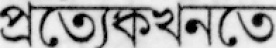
প্ৰত্যেকখনতে
